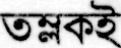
তম্লকই
